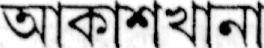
আকাশখানা
